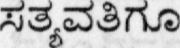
ಸತ್ಯವತಿಗೂ
